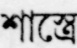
শাস্ত্রে
